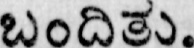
ಬಂದಿತು.
